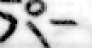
চং-
